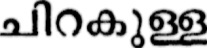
ചിറകുള്ള
